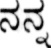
ನನ್ನ
